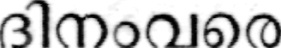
ദിനംവരെ
